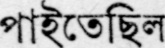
পাইতেছিল
